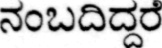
ನಂಬದಿದ್ದರೆ
